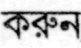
করুন
